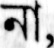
না,
